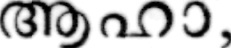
ആഹാ,
